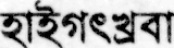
হাইগৎখ্রবা
